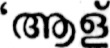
‘ആള്
